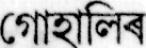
গোহালিৰ
